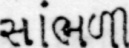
સાંભળી
